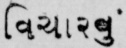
વિચારવું
